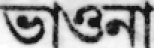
ভাওনা
